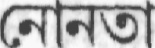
নোনতা
